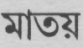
মাতয়
